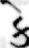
કે
